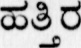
ಹತ್ತಿರ
